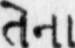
તેના
